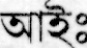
আইঃ
